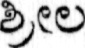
ಶ್ರೀಲ
